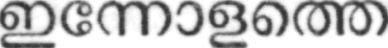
ഇന്നോളത്തെ
